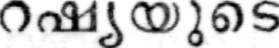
റഷ്യയുടെ
